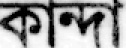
কান্দা
